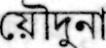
য়ৌদুনা
